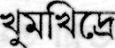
খুমখিদ্রে
